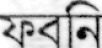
ফবনি
